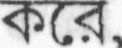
করে,
